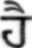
ਹੈ
